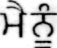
ਮੈਨੂੰ
